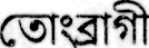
তোংব্রাগী
